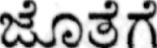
ಜೊತೆಗೆ
